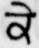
ਕੇ
